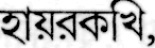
হায়রকখি,
